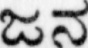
ಜನ
